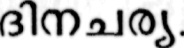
ദിനചര്യ.
